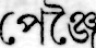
পেঞ্জৈ
